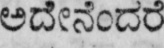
ಅದೇನೆಂದರೆ
